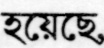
হয়েছে,
